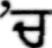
'ਚ
